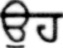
ਉਹ
